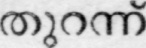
തുറന്ന്
